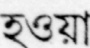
হওয়া
